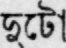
দুটো
